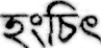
হংচিৎ
